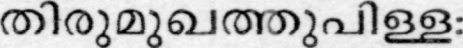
തിരുമുഖത്തുപിള്ള:
